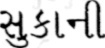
સુકાની
